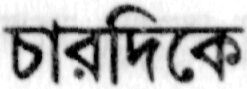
চারদিকে
